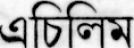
এচিলিম
